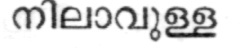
നിലാവുള്ള
